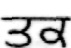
ਤਕ
